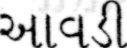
આવડી
